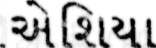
એશિયા
